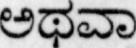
ಅಥವಾ
